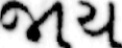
જાય
